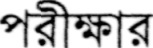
পরীক্ষার
